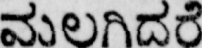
ಮಲಗಿದರೆ
